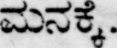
ಮನಕ್ಕೆ.
